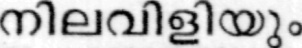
നിലവിളിയും
